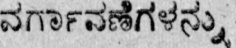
ವರ್ಗಾವಣೆಗಳನ್ನು
